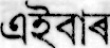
এইবাৰ
